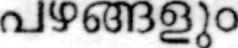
പഴങ്ങളും
